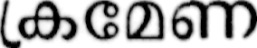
ക്രമേണ
